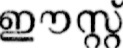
ഈസ്റ്റ്
